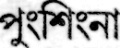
পুংশিংনা
